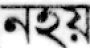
নহয়
